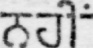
ਨਹੀਂ
